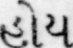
હોય
